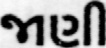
જાણી
